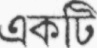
একটি
